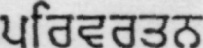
ਪਰਿਵਰਤਨ
